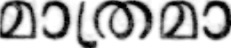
മാത്രമാ
